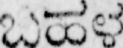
ಬಹಳ
